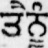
ਤੈਨੂੰ
